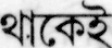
থাকেই
